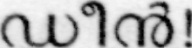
ഡീന്‍!
